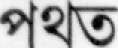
পথত
